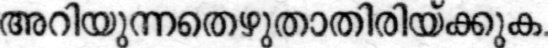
അറിയുന്നതെഴുതാതിരിയ്ക്കുക.
